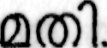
മതി.
